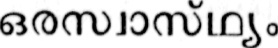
ഒരസ്വാസ്ഥ്യം
